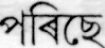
পৰিছে
